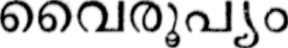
വൈരൂപ്യം
